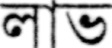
লাভ
